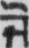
ਜੋ
